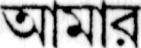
আমার
